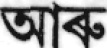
আৰু
